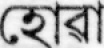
হোৱা
